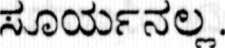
ಸೂರ್ಯನಲ್ಲ.
